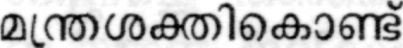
മന്ത്രശക്തികൊണ്ട്
